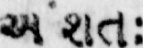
અંશતઃ
